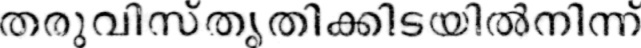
തരുവിസ്തൃതിക്കിടയില്‍നിന്ന്
